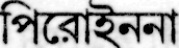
পিরোইননা
